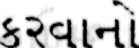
કરવાનો
